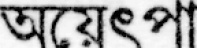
অয়েৎপা
